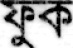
ফুক
